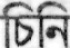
চিনি
